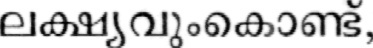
ലക്ഷ്യവുംകൊണ്ട്,
